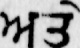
ਅਤੇ
